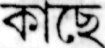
কাছে
